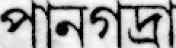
পানগদ্রা
